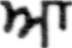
ਆ
